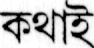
কথাই
